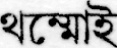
থম্মোই
